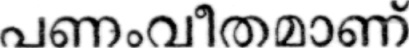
പണംവീതമാണ്
